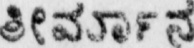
ತೀರ್ಮಾನ
